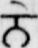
ਨੇ
